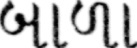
બાળા
